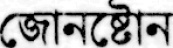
জোনষ্টোন
